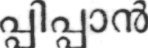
പ്പിപ്പാന്‍
